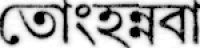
তোংহন্নবা
